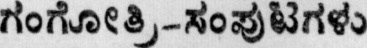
ಗಂಗೋತ್ರಿ-ಸಂಪುಟಗಳು
